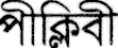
পীক্লিবী
